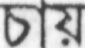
চায়
